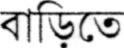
বাড়িতে
